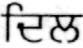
ਦਿਲ
